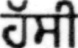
ਹੱਸੀ
